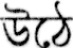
উঠে
